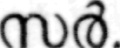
സര്‍.
